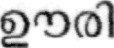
ഊരി
